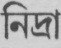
নিদ্ৰা
